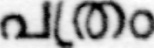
പത്രം
